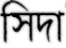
সিদা
